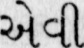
એવી
